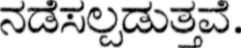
ನಡೆಸಲ್ಪಡುತ್ತವೆ.
